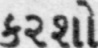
કરશો
